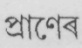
প্রাণেৰ
